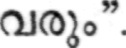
വരും".
